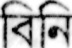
বিনি
